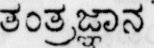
ತಂತ್ರಜ್ಞಾನ
